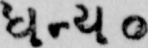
ધન્ય.
